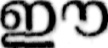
ഈ
